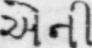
એની
